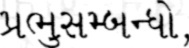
પ્રભુસમ્બન્ધો,
